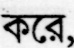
করে,
